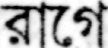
রাগে
